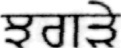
ਝਗੜੇ
